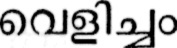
വെളിച്ചം
